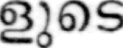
ളുടെ
